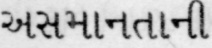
અસમાનાતાની
